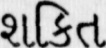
શક્તિ
